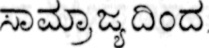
ಸಾಮ್ರಾಜ್ಯದಿಂದ.
